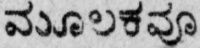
ಮೂಲಕವೂ
